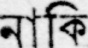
নাকি
